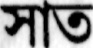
সাত
